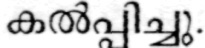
കല്‍പ്പിച്ചു.
